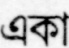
একা
